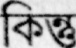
কিন্তু
